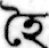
হৈ
